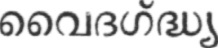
വൈദഗ്ദ്ധ്യ
